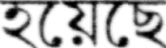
হয়েছে
